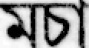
মচা
